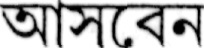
আসবেন
